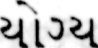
યોગ્ય
